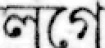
লগে
